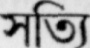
সত্যি
